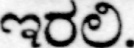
ಇರಲಿ.
